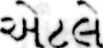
એટલે
